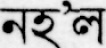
নহ'ল
